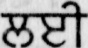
ਲਈ
